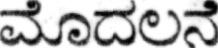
ಮೊದಲನೆ
